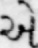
એ
